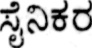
ಸೈನಿಕರ
